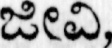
ಜೀವಿ,
